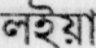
লইয়া
